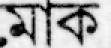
মোক
